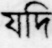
যদি
